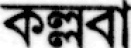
কল্লবা
